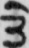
ਤੇ
